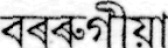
বৰৰুগীয়া
